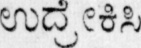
ಉದ್ರೇಕಿಸಿ
